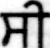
ਸੀ
